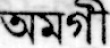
অমগী
